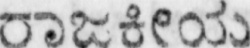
ರಾಜಕೀಯ
